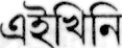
এইখিনি
